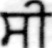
ਸੀ
